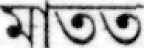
মাতত
